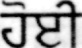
ਹੋਈ
